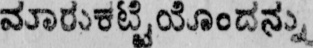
ಮಾರುಕಟ್ಟೆಯೊಂದನ್ನು
